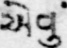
એવું
